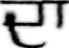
ਦਾ
